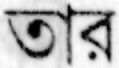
তার
